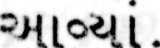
આવ્યાં.
